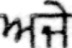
ਅਜੇ
